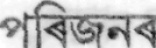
পৰিজনৰ
